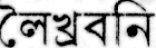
লৈখ্রবনি
